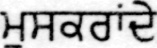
ਮੁਸਕਰਾਂਦੇ
